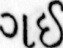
ગઈ
